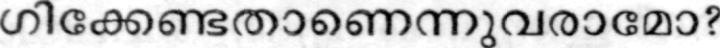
ഗിക്കേണ്ടതാണെന്നുവരാമോ?
